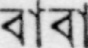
বাবা
